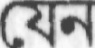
যেন
